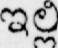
ಇಲ್ಲಿ
